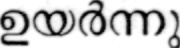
ഉയര്‍ന്നു
